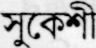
সুকেশী
